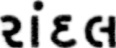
રાંદલ
